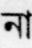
না
